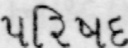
પરિષદ
